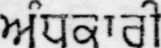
ਅੰਧਕਾਰੀ
